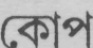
কোপ
